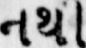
નથી
